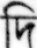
দি
